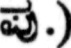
ಪು.)
